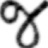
જ
